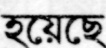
হয়েছে
